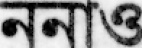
ননাও
